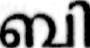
ബി
